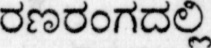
ರಣರಂಗದಲ್ಲಿ
